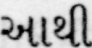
આથી
